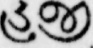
હજી
